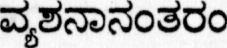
ವ್ಯಶನಾನಂತರಂ
